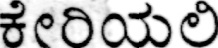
ಕೇರಿಯಲಿ
